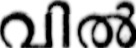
വില്‍
